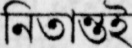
নিতান্তই
